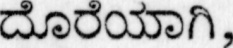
ದೊರೆಯಾಗಿ,
